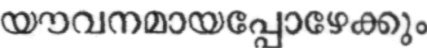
യൌവനമായപ്പോഴേക്കും
